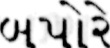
બપોરે
